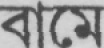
বামে
